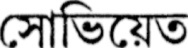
সোভিয়েত
